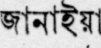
জানাইয়া
